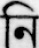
নি
